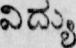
ವಿದ್ಯು
